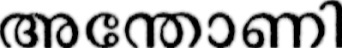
അന്തോണി
